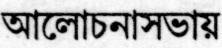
আলোচনাসভায়
